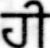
ਹੀ
